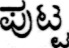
ಪುಟ್ಟ
